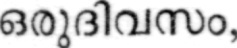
ഒരുദിവസം,
